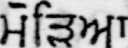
ਮੋੜਿਆ
